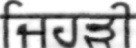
ਜਿਹੜੀ
